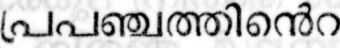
പ്രപഞ്ചത്തിന്റെ
